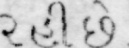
રહીછે.
